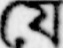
যে
